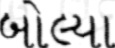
બોલ્યા
